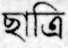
ছাত্রি
